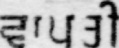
ਵਾਪਰੀ
